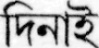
দিনাই
